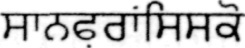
ਸਾਨਫ਼ਰਾਂਸਿਸਕੋ
